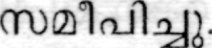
സമീപിച്ചു.
